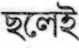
ছলেই
